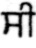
ਸੀ
